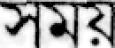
সময়
